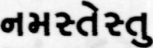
નમસ્તેસ્તુ
